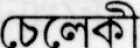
চেলেকী
